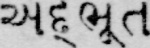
અદ્ભૂત
